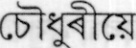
চৌধুৰীয়ে
